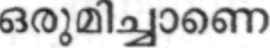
ഒരുമിച്ചാണെ
